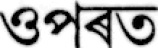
ওপৰত
